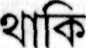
থাকি
